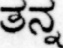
ತನ್ನ
